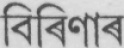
বিৰিণাৰ
